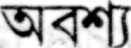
অবশ্য
